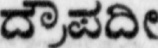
ದ್ರೌಪದೀ
